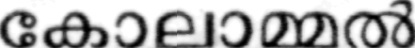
കോലാമ്മല്‍
